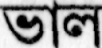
ভাল
